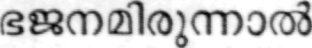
ഭജനമിരുന്നാല്‍
